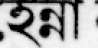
হেন্না
